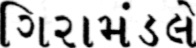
ગિરામંડલે
